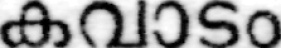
കവാടം
